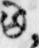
છે,
